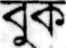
বুক
